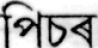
পিচৰ
